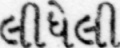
લીધેલી
